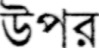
উপর
